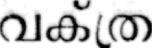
വക്ത്ര
